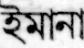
ইমানা
